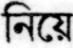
নিয়ে
